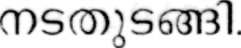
നടതുടങ്ങി.
